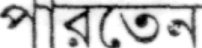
পারতেন
